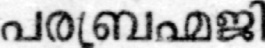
പരബ്രഹ്മജി
